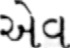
એવ
